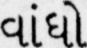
વાંધો
